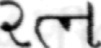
રત્ન
